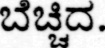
ಬೆಚ್ಚಿದ.
